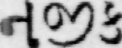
નજીક
